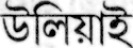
উলিয়াই
